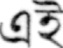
এই
